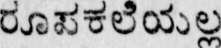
ರೂಪಕಲೆಯಲ್ಲ
